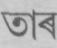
তাৰ
